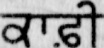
ਕਾਫ਼ੀ
